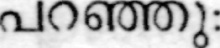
പറഞ്ഞു:
